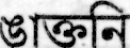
ঙাক্তনি
